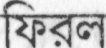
ফিরল
